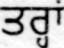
ਤਰ੍ਹਾਂ
